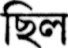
ছিল
